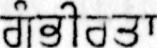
ਗੰਭੀਰਤਾ
